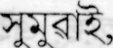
সুমুৱাই,
